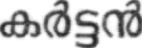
കര്‍ട്ടന്‍
